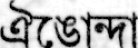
ঐঙোন্দা
